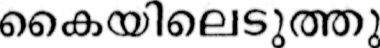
കൈയിലെടുത്തു
